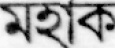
মহাক
